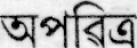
অপৱিত্র
